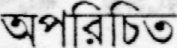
অপরিচিত
